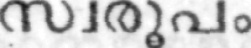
സ്വരൂപം
